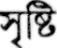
সৃষ্টি
